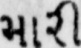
મારી
